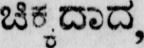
ಚಿಕ್ಕದಾದ,
